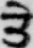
ਤੇ
